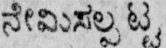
ನೇಮಿಸಲ್ಪಟ್ಟ
